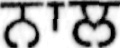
ਨਾਲ
